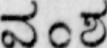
ವಂಶ
